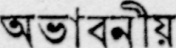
অভাবনীয়
